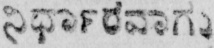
ನಿರ್ಧಾರವಾಗು
